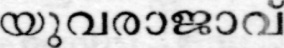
യുവരാജാവ്
